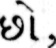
છો,
